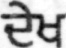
ਦੇਖ
